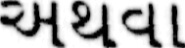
અથવા
